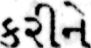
કરીને
